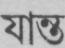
যান্ত
